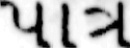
પાત્ર
